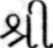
શ્રી
